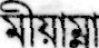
মীয়াম্না
